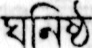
ঘনিষ্ঠ
